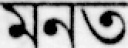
মনত
